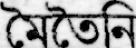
মৈতৈনি
